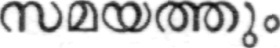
സമയത്തും
